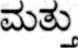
ಮತ್ತು
